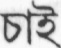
চাই
